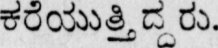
ಕರೆಯುತ್ತಿದ್ದರು.
